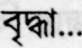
বৃদ্ধা...
